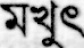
মখুৎ
